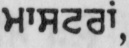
ਮਾਸਟਰਾਂ,
